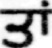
ਤਾਂ
